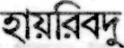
হায়রিবদু
